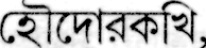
হৌদোরকখি,
